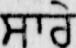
ਸਾਰੇ
